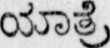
ಯಾತ್ರೆ
